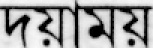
দয়াময়
